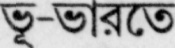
ভূ-ভারতে
